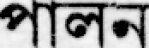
পালন
